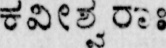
ಕವೀಶ್ವರಾಃ
